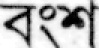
বংশ
